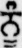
ਨੂੰ
